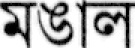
মঙাল
